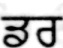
ਡਰ
